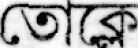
তোক্লে
